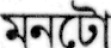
মনটো
